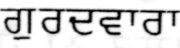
ਗੁਰਦਵਾਰਾ
